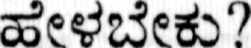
ಹೇಳಬೇಕು?
